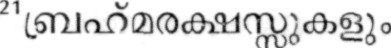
21ബ്രഹ്മരക്ഷസ്സുകളും
